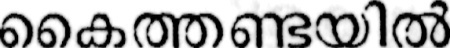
കൈത്തണ്ടയില്‍
